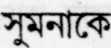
সুমনাকে
